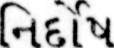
નિર્દોષ
